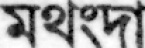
মথংদা
